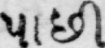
પાછી
